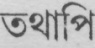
তথাপি
